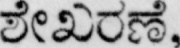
ಶೇಖರಣೆ,
